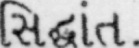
સિદ્ધાંત.
